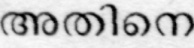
അതിനെ
